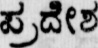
ಪ್ರದೇಶ
